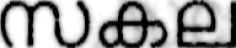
സകല
